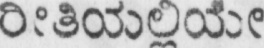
ರೀತಿಯಲ್ಲಿಯೇ
